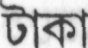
টাকা
